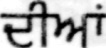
ਦੀਆਂ
